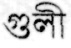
গুলী
